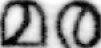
മര
